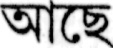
আছে
